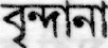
বৃন্দানা
